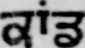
ਕਾਂਡ
